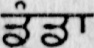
ਡੰਡਾ
